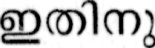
ഇതിനു
